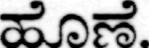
ಹೊಣೆ.
